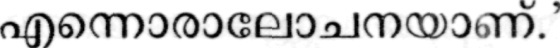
എന്നൊരാലോചനയാണ്.'
